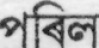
পৰিল
